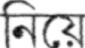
নিয়ে
